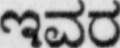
ಇವರ
